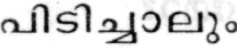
പിടിച്ചാലും
